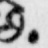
છે.
